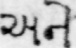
અને
